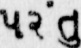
પરંતુ
